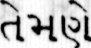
તેમણે
